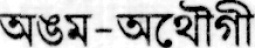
অঙম-অথৌগী
